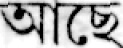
আছে
